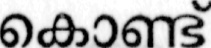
കൊണ്ട്
